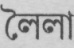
লৈলা
